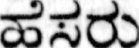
ಹೆಸರು
